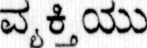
ವ್ಯಕ್ತಿಯು
